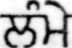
ਲੰਮੇ
